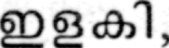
ഇളകി,
